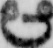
ಆ
